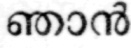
ഞാന്‍
